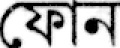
ফোন
